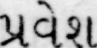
પ્રવેશ
